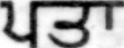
ਪਤਾ
